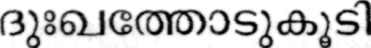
ദുഃഖത്തോടുകൂടി
